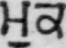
ਮੁਕ
